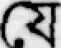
যে
